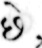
છે,
